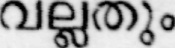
വല്ലതും
